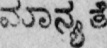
ಮಾನ್ಯತೆ
